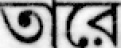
তারে
